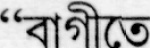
"বাগীতে
